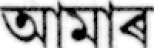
আমাৰ
